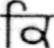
ਕਿ
